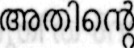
അതിന്റെ
